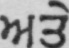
ਅਤੇ
